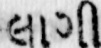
લાગી
